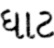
ધાટ
